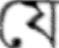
যে
